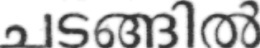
ചടങ്ങില്‍
